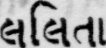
લલિતા
